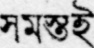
সমস্তই
